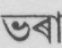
ভৰা
